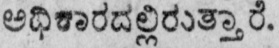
ಅಧಿಕಾರದಲ್ಲಿರುತ್ತಾರೆ.
